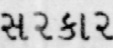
સરકાર
